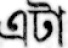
এটা
